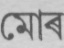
মোৰ
